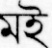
মই
